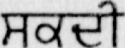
ਸਕਦੀ
